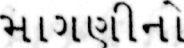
માગણીનો
